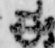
ಈ
